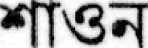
শাওন
